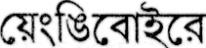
য়েংঙিবোইরে
